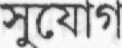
সুযোগ
